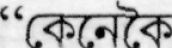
"কেনেকৈ
